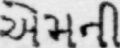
એમની
